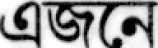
এজনে
